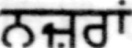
ਨਜ਼ਰਾਂ
